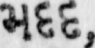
મદદ,
